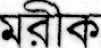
মরীক
